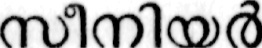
സീനിയര്‍
